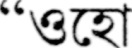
“ওহো
